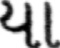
યા
